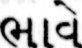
ભાવે
